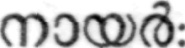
നായര്‍:
